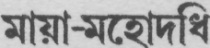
মায়া-মহোদধি
